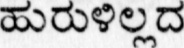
ಹುರುಳಿಲ್ಲದ
